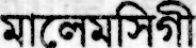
মালেসিগী
